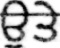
ਉਤੇ
